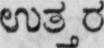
ಉತ್ತರ
